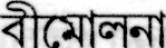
বীমোলনা
